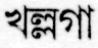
খল্লগা
